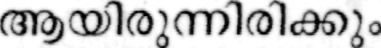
ആയിരുന്നിരിക്കും
